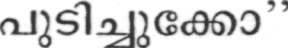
പുടിച്ചുക്കോ”
